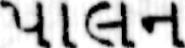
પાલન
